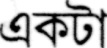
একটা
